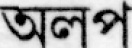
অলপ
